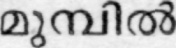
മുമ്പില്‍
